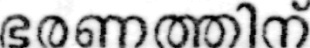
ഭരണത്തിന്
